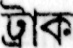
ট্রাক
